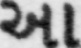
આ
